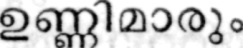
ഉണ്ണിമാരും
